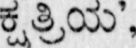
ಕ್ಷತ್ರಿಯ’,
